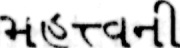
મહત્ત્વની
